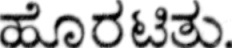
ಹೊರಟಿತು.
